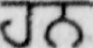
ਹਨ
